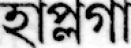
হাপ্লগা
